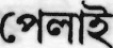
পেলাই
